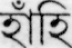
হাঁহি
